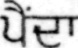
ਪੈਂਦਾ
